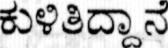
ಕುಳಿತಿದ್ದಾನೆ
